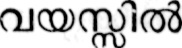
വയസ്സില്‍
